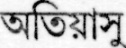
অতিয়াসু
